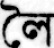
লৈ
